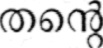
തന്റെ
